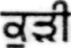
ਕੁੜੀ
